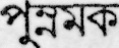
পুম্নমক
